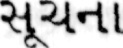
સૂચના
